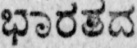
ಭಾರತದ
